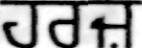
ਹਰਜ਼
